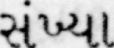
સંખ્યા
